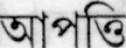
আপত্তি
